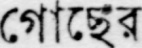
গোছের
